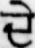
ਦੇ
